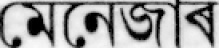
মেনেজাৰ
